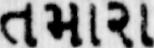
તમારા
